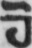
ਹੋ
